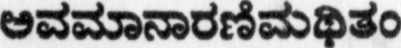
ಅವಮಾನಾರಣಿಮಥಿತಂ
